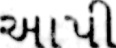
આપી
